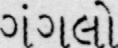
ગંગલો
